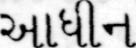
આધીન
